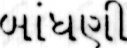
બાંધણી
